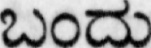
ಬಂದು
